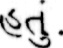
હતું.
